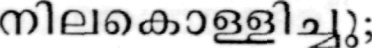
നിലകൊള്ളിച്ചു;
